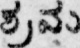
ಶ್ರಮ
